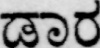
ಡಾರ
